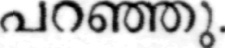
പറഞ്ഞു.
